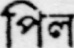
পিল
